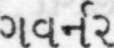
ગવર્નર
